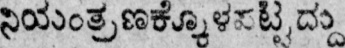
ನಿಯಂತ್ರಣಕ್ಕೊಳಪಟ್ಟಿದ್ದು
